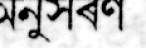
অনুসৰণ
